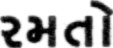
રમતો
